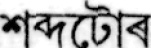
শব্দটোৰ
